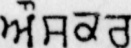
ਔਸਕਰ
